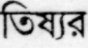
তিষ্যর
